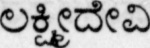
ಲಕ್ಷ್ಮೀದೇವಿ
